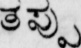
ತಪ್ಪು
